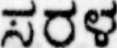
ಸರಳ
